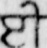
ਈ
